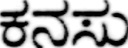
ಕನಸು
